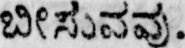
ಬೀಸುವವು.
